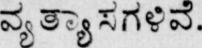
ವ್ಯತ್ಯಾಸಗಳಿವೆ.
